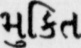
મુક્તિ
